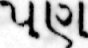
પણ
